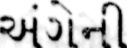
અંગેની
